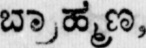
ಬ್ರಾಹ್ಮಣ,
